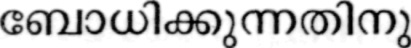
ബോധിക്കുന്നതിനു
